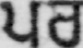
ਪਰ
